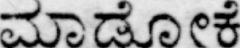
ಮಾಡೋಕೆ
